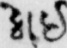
કોઈ
